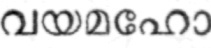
വയമഹോ
